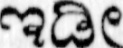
ಇಡೀ
